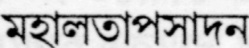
মহালতাপসাদন
